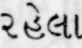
રહેલા
